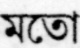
মতো
